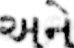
અને
